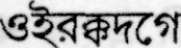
ওইরক্কদগে
